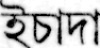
ইচাদা
